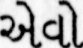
એવો
